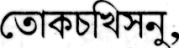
তোকচখিসনু,
